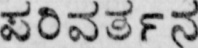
ಪರಿವರ್ತನ
